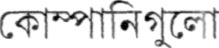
কোম্পানিগুলো
